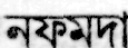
নফমদা
